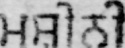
ਮਸ਼ੀਨੀ
